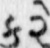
કરે
